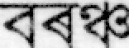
বৰঞ্চ
